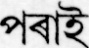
পৰাই
